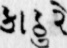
કાઠુરે
